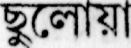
ছুলোয়া
